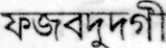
ফজবদুদগী
